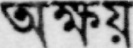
অক্ষয়
